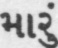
મારું
